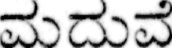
ಮದುವೆ
